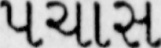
પચાસ
